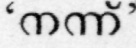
'നന്ന്'
